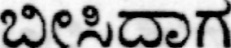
ಬೀಸಿದಾಗ
